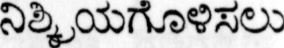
ನಿಶ್ಕ್ರಿಯಗೊಳಿಸಲು
